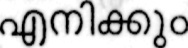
എനിക്കും
